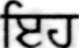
ਇਹ
